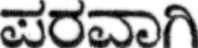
ಪರವಾಗಿ
